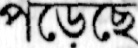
পড়েছে
